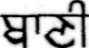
ਬਾਣੀ
